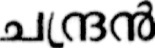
ചന്ദ്രന്‍
